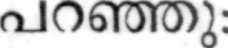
പറഞ്ഞു:
